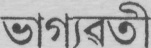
ভাগ্যৱতী
